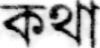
কথা
